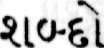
શબ્દો
